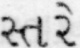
સ્તરે
